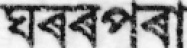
ঘৰৰপৰা
